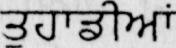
ਤੁਹਾਡੀਆਂ
